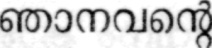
ഞാനവന്റെ
